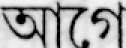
আগে
